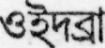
ওইদব্রা
